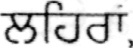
ਲਹਿਰਾਂ,
